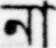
না
